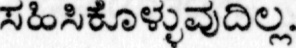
ಸಹಿಸಿಕೊಳ್ಳುವುದಿಲ್ಲ.
